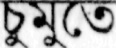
চুমুতে
